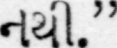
નથી.”
